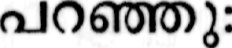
പറഞ്ഞു:
